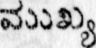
ಮುಖ್ಯ
